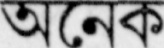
অনেক
